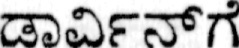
ಡಾರ್ವಿನ್ಗೆ
